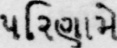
પરિણામે
